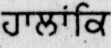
ਹਾਲਾਂਕਿ
